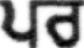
ਪਰ
